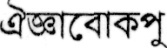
ঐজ্ঞাবোকপু
